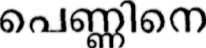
പെണ്ണിനെ
